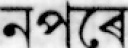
নপৰে
